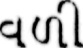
વળી
